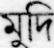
মুদি
